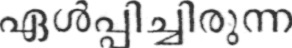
ഏള്‍പ്പിച്ചിരുന്ന
